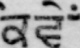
ਕਿਵੇਂ
